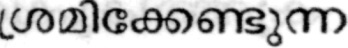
ശ്രമിക്കേണ്ടുന്ന
